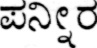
ಪನ್ನೀರ
